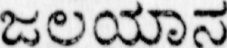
ಜಲಯಾನ
